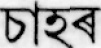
চাহৰ
